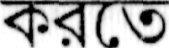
করতে
